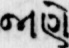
જાણે
